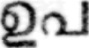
ഉപ
